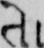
તો
